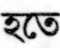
হতে
